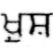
ਖ਼ੁਸ਼
